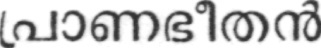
പ്രാണഭീതന്‍
